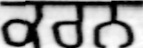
ਕਰਨ
